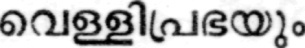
വെള്ളിപ്രഭയും
